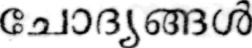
ചോദ്യങ്ങള്‍
